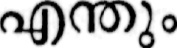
എന്തും
